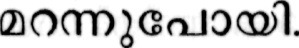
മറന്നുപോയി.
